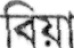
বিয়া
